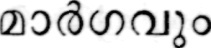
മാര്‍ഗവും
